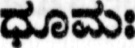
ಧೂಮಃ
